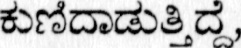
ಕುಣಿದಾಡುತ್ತಿದ್ದೆ,
